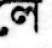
লৈ
